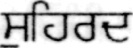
ਸੁਹਿਰਦ
